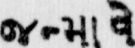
જન્માવે
